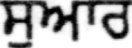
ਸੁਆਰ
